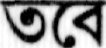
তবে
